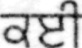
ਕਈ
